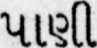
પાણી
